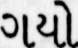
ગયો
